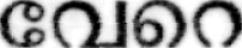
വേറെ
